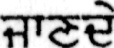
ਜਾਣਦੇ
